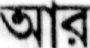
আর
